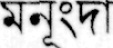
মনূংদা
